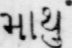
માથું
